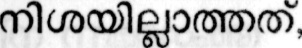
നിശയില്ലാത്തത്,
